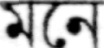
মনে
